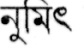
নুমিৎ
